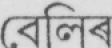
বেলিৰ
